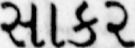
સાકર
